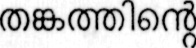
തങ്കത്തിന്റെ
